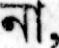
না,
